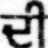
ਦੀ
